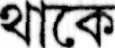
থাকে
